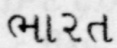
ભારત
